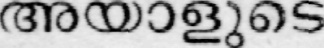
അയാളുടെ
